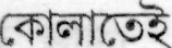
কোলাতেই
